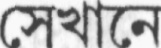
সেখানে
